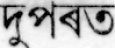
দুপৰত
